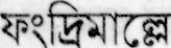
ফংদ্রিমাল্লে
